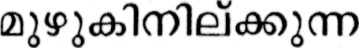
മുഴുകിനില്ക്കുന്ന
